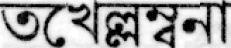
তখেল্লম্বনা
